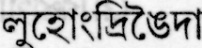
লুহোংদ্রিঙৈদা
